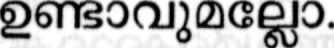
ഉണ്ടാവുമല്ലോ.
